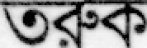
তরুক
